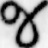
જ
